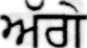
ਅੱਗੇ
